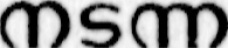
നടന്ന
